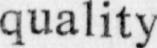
quality
